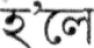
হ'লে
